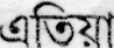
এতিয়া
